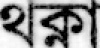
থক্না
